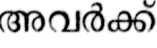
അവര്‍ക്ക്
